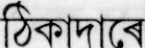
ঠিকাদাৰে
